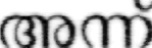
അന്ന്
